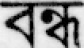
বন্ধ
